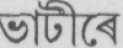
ভাটীৰে
